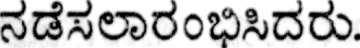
ನಡೆಸಲಾರಂಭಿಸಿದರು.
